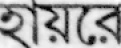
হায়রে
